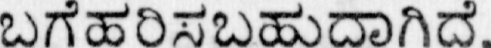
ಬಗೆಹರಿಸಬಹುದಾಗಿದೆ.
